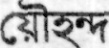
য়ৌহন্দ
